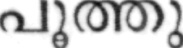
പൂത്തു
